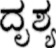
ದೃಶ್ಯ
